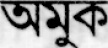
অমুক
